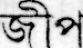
জীপ
